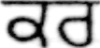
ਕਰ
